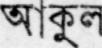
আকুল
